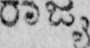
ರಾಜ್ಯ
